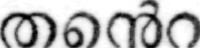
തന്റെ
